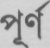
পূৰ্ণ
